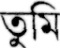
তুমি
